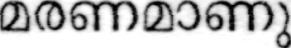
മരണമാണു
